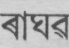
ৰাঘৱ
